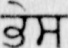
ਭੇਸ
